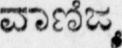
ವಾಣಿಜ್ಯ
